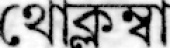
থোক্লম্বা
